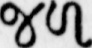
જળ
